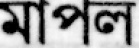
মাপল
